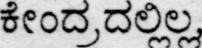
ಕೇಂದ್ರದಲ್ಲಿಲ್ಲ,
